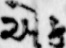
એક
